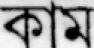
কাম
